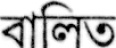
বালিত
